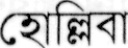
হোল্লিবা
